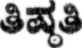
ತಿಷ್ಠತಿ
